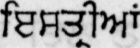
ਇਸਤ੍ਰੀਆਂ
